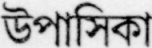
উপাসিকা
